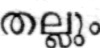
തല്ലും
